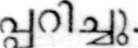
പ്പറിച്ചു.
